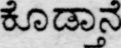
ಕೊಡ್ತಾನೆ
